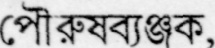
পৌরুষব্যঞ্জক,
